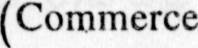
(Commerce
